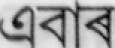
এবাৰ
